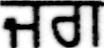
ਜਗ
